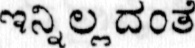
ಇನ್ನಿಲ್ಲದಂತೆ
